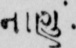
નાણું.
